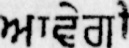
ਆਵੇਗੀ
